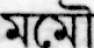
মমৌ
